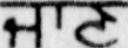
ਜਾਣ
